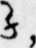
કે,
